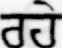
ਰਹੇ
